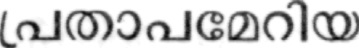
പ്രതാപമേറിയ
